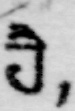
ਹੈ,
